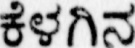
ಕೆಳಗಿನ
